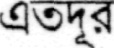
এতদূর
